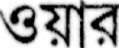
ওয়ার
